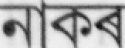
নাকৰ
